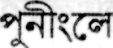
পুনীংলে
